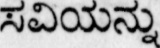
ಸವಿಯನ್ನು
